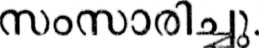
സംസാരിച്ചു.
